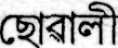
ছোৱালী
